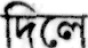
দিলে
